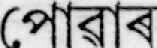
পোৱাৰ
